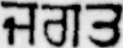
ਜਗਤ
